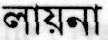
লায়না
